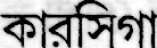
কারসিগা
